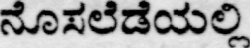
ನೊಸಲೆಡೆಯಲ್ಲಿ
